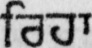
ਰਿਹਾ
